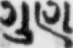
ગુણ
